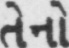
તેનો
